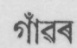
গাঁৱৰ
